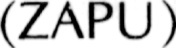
(ZAPU)
